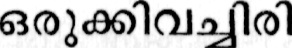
ഒരുക്കിവച്ചിരി
